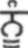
ਨੂੰ
